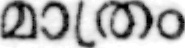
മാത്രം
